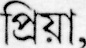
প্রিয়া,
